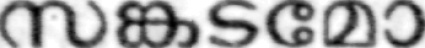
സങ്കടമോ
